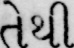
તેથી
